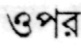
ওপর
